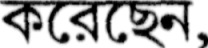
করেছেন,
